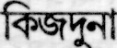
কিজদুনা
